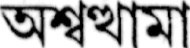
অশ্বত্থামা
